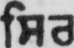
ਸਿਰ
